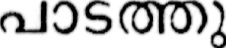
പാടത്തു
